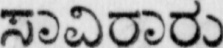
ಸಾವಿರಾರು
